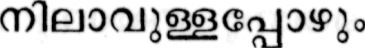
നിലാവുള്ളപ്പോഴും
